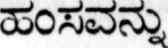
ಹಂಸವನ್ನು
